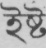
ইষ্ট
